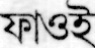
ফাওই
